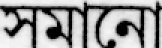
সমানো
